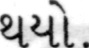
થયો.
